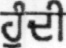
ਹੁੰਦੀ
